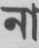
না
